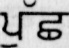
ਪੁੱਛ
